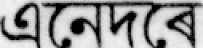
এনেদৰে
